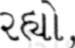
રહ્યો,
